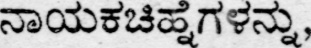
ನಾಯಕಚಿಹ್ನೆಗಳನ್ನು,
